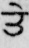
ਤੇ
